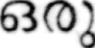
ഒരു
